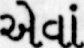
એવાં
